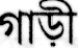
গাড়ী
